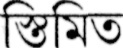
স্তিমিত
